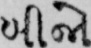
બીજો
